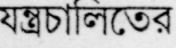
যন্ত্রচালিতের
